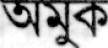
অমুক
